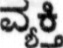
ವ್ಯಕ್ತಿ
